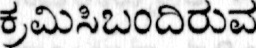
ಕ್ರಮಿಸಿಬಂದಿರುವ
